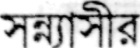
সন্ন্যাসীর
